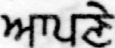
ਆਪਣੇ
